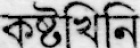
কষ্টখিনি
